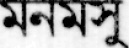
মনমসু
